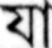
যা
